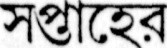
সপ্তাহের
